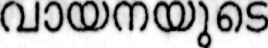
വായനയുടെ
